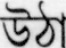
উঠা
